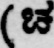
(ಚ
